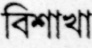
বিশাখা
